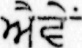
ਐਵੇਂ
